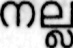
നല്ല
